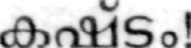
കഷ്ടം!
